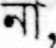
না,
